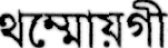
থম্মোয়গী
